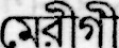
মেরীগী
